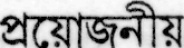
প্রয়োজনীয়
